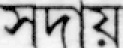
সদায়
